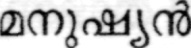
മനുഷ്യന്‍
